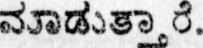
ಮಾಡುತ್ತಾರೆ.
